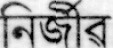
নির্জীৱ
